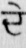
ਦੇ
